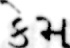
કમ
